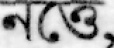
নত্তে,
